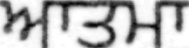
ਆਤਮਾ
